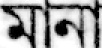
মানা
